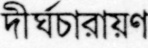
দীর্ঘচারায়ণ
